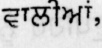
ਵਾਲੀਆਂ,
